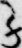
કે
